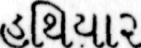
હથિયાર
